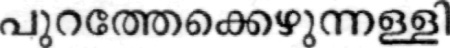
പുറത്തേക്കെഴുന്നള്ളി
